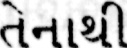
તેનાથી
